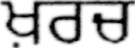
ਖ਼ਰਚ
